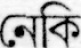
নেকি
